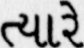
ત્યારે
